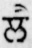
ਲੈ
